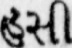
હસી
